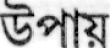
উপায়
